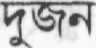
দুজন
